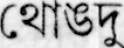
থোঙদু
